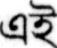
এই
